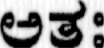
ಅತಃ
